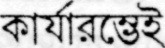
কার্যারম্ভেই
